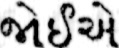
જોઈએ
